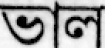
ভাল
